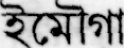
ইমৌগা
